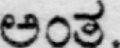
ಅಂತ.
